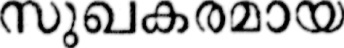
സുഖകരമായ
